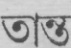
তান্ত
